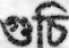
গুচি
